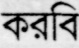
করবি
